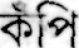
কঁপি
